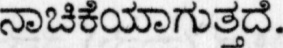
ನಾಚಿಕೆಯಾಗುತ್ತದೆ.
